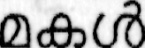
മകള്‍
